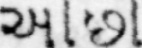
આછા
